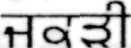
ਜਕੜੀ
